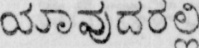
ಯಾವುದರಲ್ಲಿ
